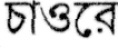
চাওরে
